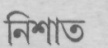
নিশাত
